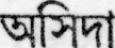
অসিদা
